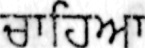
ਚਾਹਿਆ
